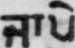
ਜਾਪੇ
